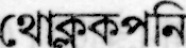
থোক্লকপনি
